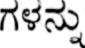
ಗಳನ್ನು
